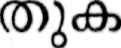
തുക
